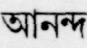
আনন্দ
